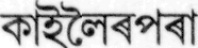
কাইলৈৰপৰা
